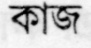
কাজ
